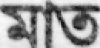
মাত
